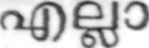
എല്ലാ
